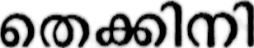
തെക്കിനി
